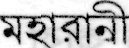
মহারানী
